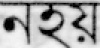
নহয়
